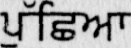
ਪੁੱਛਿਆ
